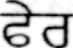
ਫੇਰ
